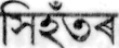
সিহঁতৰ
